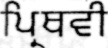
ਪ੍ਰਿਥਵੀ
